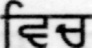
ਵਿਚ
